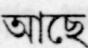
আছে
